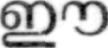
ഈ
